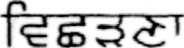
ਵਿਛੜਣਾ
